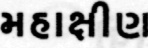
મહાક્ષીણ
